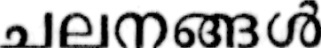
ചലനങ്ങള്‍
